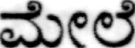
ಮೇಲೆ
